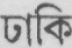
ঢাকি
